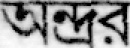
অন্দর
